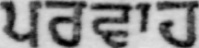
ਪਰਵਾਹ
